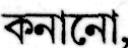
কনানো,
